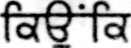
ਕਿਉਂਕਿ
